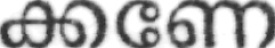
ക്കണേ
